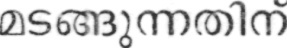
മടങ്ങുന്നതിന്
